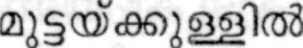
മുട്ടയ്ക്കുള്ളില്‍
